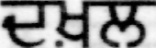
ਦਖ਼ਲ
